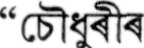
"চৌধুৰীৰ
